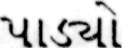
પાડ્યો
